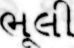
ભૂલી
